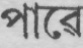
পাৱে
